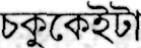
চকুকেইটা
